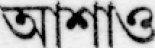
আশাও
